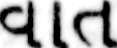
વાત
